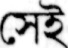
সেই
